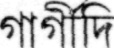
গার্গীদি
